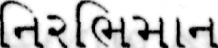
નિરભિમાન
